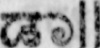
ಡಾ||
